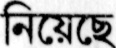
নিয়েছে
